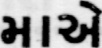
માએ
